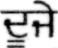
ਦੂਜੇ
